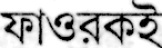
ফাওরকই
